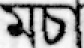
মচা
